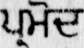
ਪ੍ਰਮੋਦ
